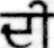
ਦੀ
